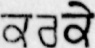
ਕਰਕੇ
